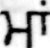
ਮਾਂ
